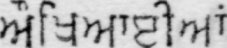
ਔਖਿਆਈਆਂ
